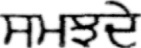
ਸਮਝਦੇ
